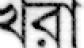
খরা
